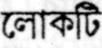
লোকটি
